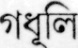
গধূলি
